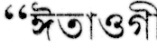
“ঈতাওগী
